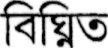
বিঘ্নিত
